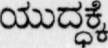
ಯುದ್ಧಕ್ಕೆ
